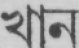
খান
